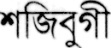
শজিবুগী
